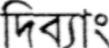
দিব্যাং
